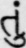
તું
